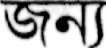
জন্য
